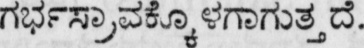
ಗರ್ಭಸ್ರಾವಕ್ಕೊಳಗಾಗುತ್ತದೆ.
